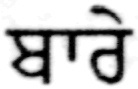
ਬਾਰੇ
